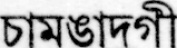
চামঙাদগী
